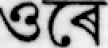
ওৰে
